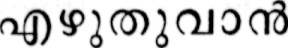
എഴുതുവാന്‍
